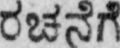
ರಚನೆಗೆ
